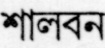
শালবন
